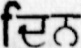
ਦਿਨ
